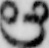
ಆ
